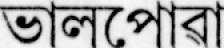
ভালপোৱা
